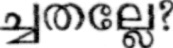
ച്ചതല്ലേ?
